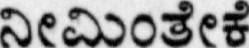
ನೀಮಿಂತೇಕೆ
